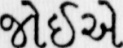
જોઈએ
